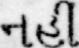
નહી
